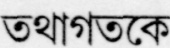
তথাগতকে
